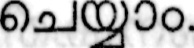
ചെയ്യാം.
